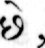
છે,
